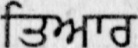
ਤਿਆਰ
